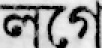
লগে
